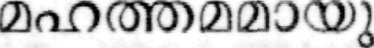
മഹത്തമമായു
